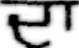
ਦਾ
